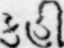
કહી
